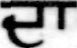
ਦਾ
